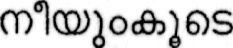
നീയുംകൂടെ
